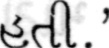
હતી.'
